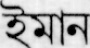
ইমান
